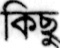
কিছু
